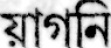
য়াগনি
